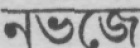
নভজে
